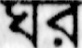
ঘর
